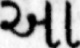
આ
